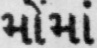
મોંમાં
